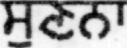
ਸੁਣਨਾ
